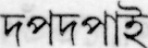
দপদপাই
